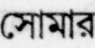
সোমার
